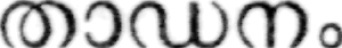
താഡനം
